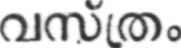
വസ്ത്രം
